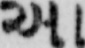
આ
